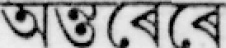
অন্তৰেৰে
